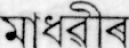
মাধৱীৰ
